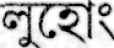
লুহোং
